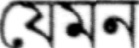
যেমন
